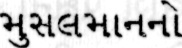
મુસલમાનનો
